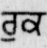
ਰੁਕ
